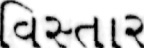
વિસ્તાર
